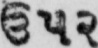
ઉપર
